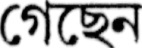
গেছেন
